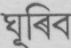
ঘূৰিব
